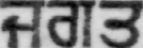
ਜਗਤ
